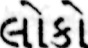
લોકો
